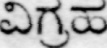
ವಿಗ್ರಹ
